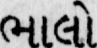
ભાલો
